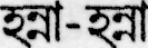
হন্না-হন্না
